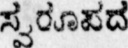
ಸ್ವರೂಪದ
